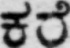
ಕರೆ
